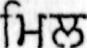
ਮਿਲ
